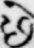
છે
